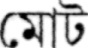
মোট
